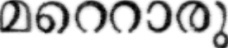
മറെറാരു
